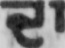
ਦਾ
